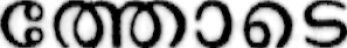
ത്തോടെ
